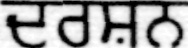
ਦਰਸ਼ਨ
